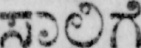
ಸಾಲಿಗೆ
